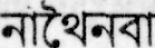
নাথৈনবা
